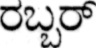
ರಬ್ಬರ್
